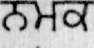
ਨਮਕ
